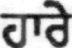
ਹਾਰੇ
